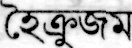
হৈক্রুজম
